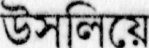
উসলিয়ে
